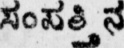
ಸ೦ಪತ್ತಿನ
